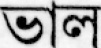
ভাল
